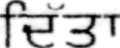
ਦਿੱਤਾ
